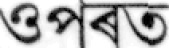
ওপৰত
